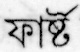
ফার্ষ্ট
